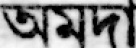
অমদা
